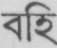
বহি
